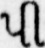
પી
